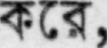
করে,
